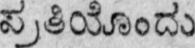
ಪ್ರತಿಯೊಂದು
